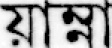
য়াম্না
